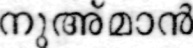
നുഅ്മാന്‍
